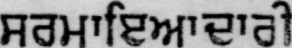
ਸਰਮਾਇਆਦਾਰੀ
